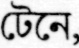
টেনে,
